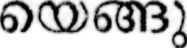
യെങ്ങു
